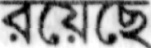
রয়েছে
